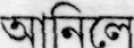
আনিলে
